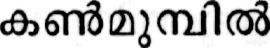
കണ്‍മുമ്പില്‍
